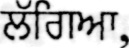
ਲੱਗਿਆ,
